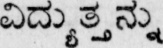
ವಿದ್ಯುತ್ತನ್ನು
